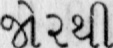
જોરથી
